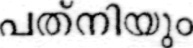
പത്നിയും
